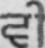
ਵੀ
